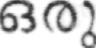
ഒരു
